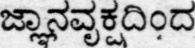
ಜ್ಞಾನವೃಕ್ಷದಿ೦ದ
